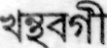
খন্থবগী
